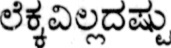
ಲೆಕ್ಕವಿಲ್ಲದಷ್ಟು
